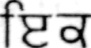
ਇਕ
